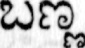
ಬಣ್ಣ
